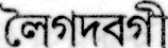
লৈগদবগী
